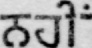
ਨਹੀਂ
